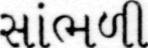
સાંભળી
